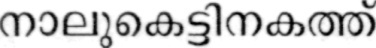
നാലുകെട്ടിനകത്ത്
